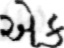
એક
